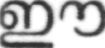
ഈ
